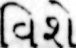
વિશે
